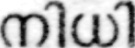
നിധി
